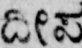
ದೀಪ
